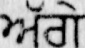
ਅੱਗੇ
